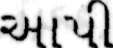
આપી
